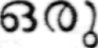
ഒരു
